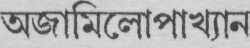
অজামিলোপাখ্যান,
